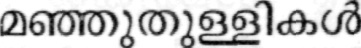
മഞ്ഞുതുള്ളികള്‍
